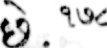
છે.૧૭૮
